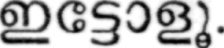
ഇട്ടോളൂ.
